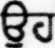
ਉਹ
